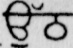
ਉੱਠ
